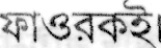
ফাওরকই।
